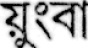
য়ুংবা
